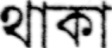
থাকা
